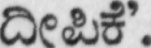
ದೀಪಿಕೆ’.
